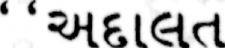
"અદાલત
